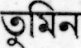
তুমিন
